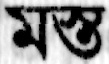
মস্ত
